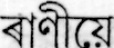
ৰাণীয়ে
